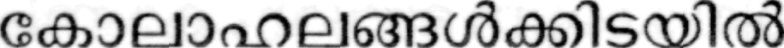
കോലാഹലങ്ങള്‍ക്കിടയില്‍
